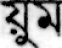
য়ুম
